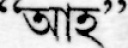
"আহ"
